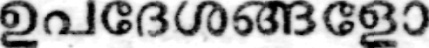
ഉപദേശങ്ങളോ
